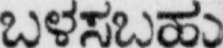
ಬಳಸಬಹು
